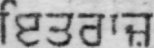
ਇਤਰਾਜ਼
